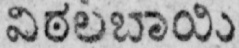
ವಿಠಲಬಾಯಿ
